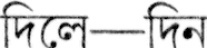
দিলে-দিন
